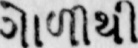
ગોળીથી
